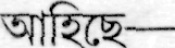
আহিছে-
